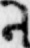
ને
